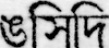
ঙসিদি
